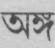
অঙ্গ
